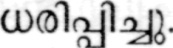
ധരിപ്പിച്ചു.
